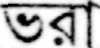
ভরা
